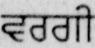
ਵਰਗੀ
